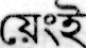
য়েংই
